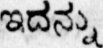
ಇದನ್ನು
